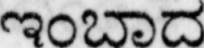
ಇಂಬಾದ
